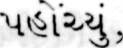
પહોંચ્યું,
